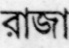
রাজা
